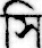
সি
